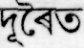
দূৰৈত
